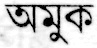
অমুক
